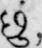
છું,
